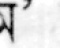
অ'
